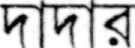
দাদার
